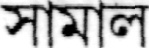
সামাল
